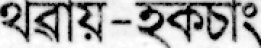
থৱায়-হকচাং
